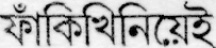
ফাঁকিখিনিয়েই
